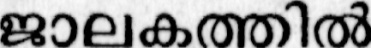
ജാലകത്തില്‍
